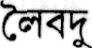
লৈবদু
